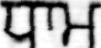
ਧਾਮ
